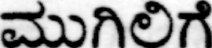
ಮುಗಿಲಿಗೆ
